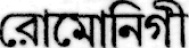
রোমোনিগী
